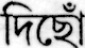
দিছোঁ
